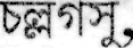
চল্লগসু,
